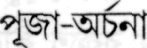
পূজা-অর্চনা
